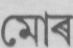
মোৰ
